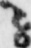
કે
